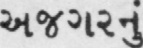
અજગરનું
